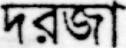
দরজা
